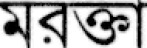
মরক্তা
